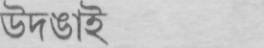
উদঙাই
